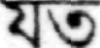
যত
